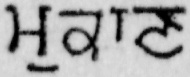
ਮੁਕਾਣ
